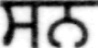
ਸਨ
